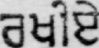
ਰਖੀਏ
